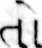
તો
